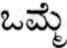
ಒಮ್ಮೆ
